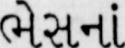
ભેંસનાં
